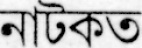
নাটকত
